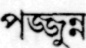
পজ্জুন্ন
